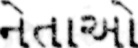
નેતાઓ
